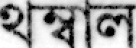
থম্বাল
